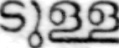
ടുള്ള
